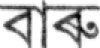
বাৰু
